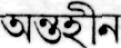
অন্তহীন
